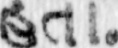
હતા.
